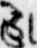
હો
